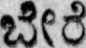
ಬೇರೆ
